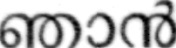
ഞാന്‍
